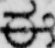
ಈ
